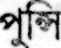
পুন্সি
